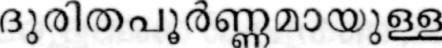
ദുരിതപൂര്‍ണ്ണമായുള്ള
